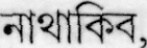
নাথাকিব,
